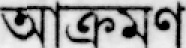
আক্রমণ
